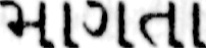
માગતા
